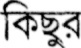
কিছুর
